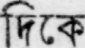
দিকে
